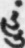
હું
